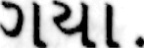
ગયા.
